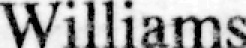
Williams
